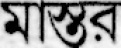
মাস্তর
